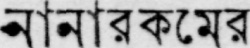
নানারকমের
